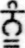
ਨੂੰ
